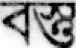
বস্তু
